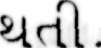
થતી.
